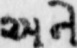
અને
